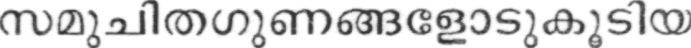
സമുചിതഗുണങ്ങളോടുകൂടിയ
